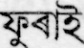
ফুৰাই
